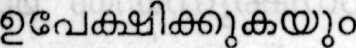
ഉപേക്ഷിക്കുകയും
